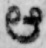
ಆ
